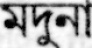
মদুনা
